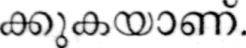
ക്കുകയാണ്.
